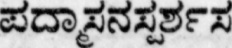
ಪದ್ಮಾಸನಸ್ಪರ್ಶಸ
